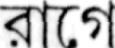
রাগে
